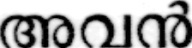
അവന്‍
